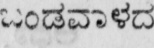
ಬಂಡವಾಳದ
